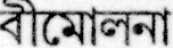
বীমোলনা
